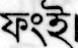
ফংই।
